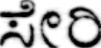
ಸೇರಿ
